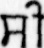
ਸੀ
